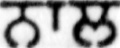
ਨਾਲ
